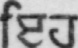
ਇਹ
